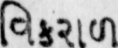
વિકરાળ
